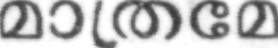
മാത്രമേ
